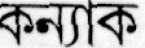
কন্যাক
